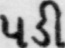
પડી
